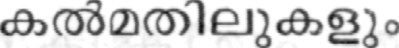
കല്‍മതിലുകളും
